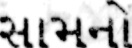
સામનો
